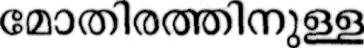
മോതിരത്തിനുള്ള
